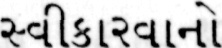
સ્વીકારવાનો
